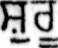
ਸ਼ੁਰੂ
